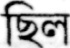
ছিল
